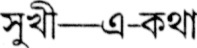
সুখী–এ-কথা
